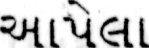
આપેલા
